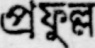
প্রফুল্ল
